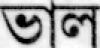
ভাল
